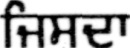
ਜਿਸਦਾ
